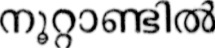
നൂറ്റാണ്ടില്‍
